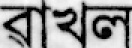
ৱাখল
